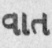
વાત
